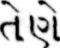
તેણે
